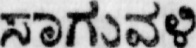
ಸಾಗುವಳಿ
